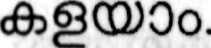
കളയാം.
